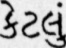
કેટલું
